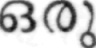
ഒരു
